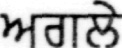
ਅਗਲੇ
